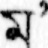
ম’
